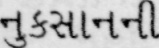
નુકસાનની
